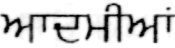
ਆਦਮੀਆਂ
